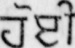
ਹੋਈ
